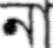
না
